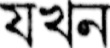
যখন
